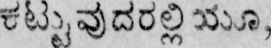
ಕಟ್ಟುವುದರಲ್ಲಿಯೂ,
